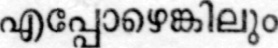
എപ്പോഴെങ്കിലും
